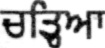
ਚੜ੍ਹਿਆ
